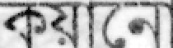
কয়ানো
